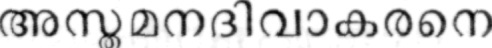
അസ്തമനദിവാകരനെ
